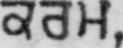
ਕਰਮ,
